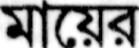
মায়ের
